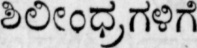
ಶಿಲೀಂಧ್ರಗಳಿಗೆ
